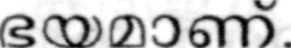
ഭയമാണ്.
